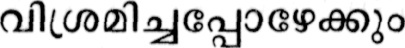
വിശ്രമിച്ചപ്പോഴേക്കും
